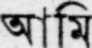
আমি
